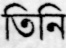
তিনি
